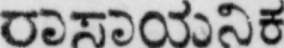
ರಾಸಾಯನಿಕ
